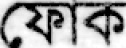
ফোক
